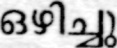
ഒഴിച്ചു
